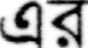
এর
